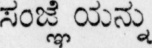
ಸಂಜ್ಞೆಯನ್ನು
